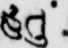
હતું.
